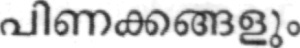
പിണക്കങ്ങളും
